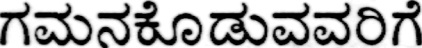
ಗಮನಕೊಡುವವರಿಗೆ
